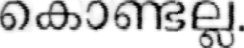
കൊണ്ടല്ല.
